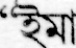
“ইমা
